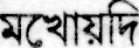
মখোয়দি
